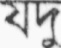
যদু
